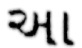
આ
